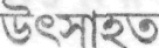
উৎসাহত
